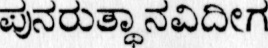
ಪುನರುತ್ಥಾನವಿದೀಗ
